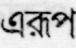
এরূপ
